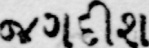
જગદીશ
